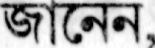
জানেন,
